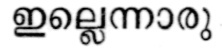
ഇല്ലെന്നാരു
